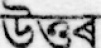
উত্তৰ
